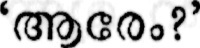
‘ആരേം?’
